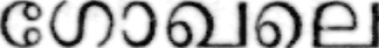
ഗോഖലെ
